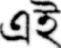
এই
